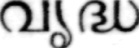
വൃദ്ധ
